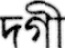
দগী
